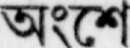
অংশে
